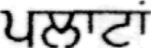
ਪਲਾਟਾਂ
